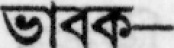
ভাবক-
